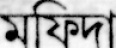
মফিদা
